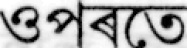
ওপৰতে
